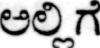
ಅಲ್ಲಿಗೆ
